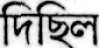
দিছিল
